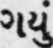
ગયું
